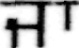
ਜਾ
